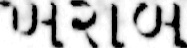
ખરાબ
